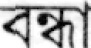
বন্ধা
